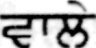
ਵਾਲੇ
